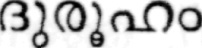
ദുരൂഹം
